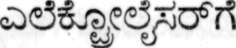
ಎಲೆಕ್ಟ್ರೋಲೈಸರ್‌ಗೆ
